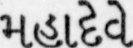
મહાદેવે
